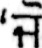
'ਜੋ
